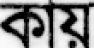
কায়
